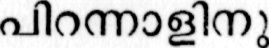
പിറന്നാളിനു
